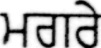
ਮਗਰੇ
